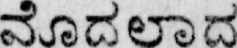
ಮೊದಲಾದ
